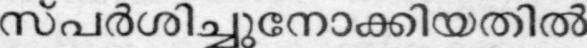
സ്പര്‍ശിച്ചുനോക്കിയതില്‍
